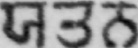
ਯਤਨ
